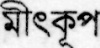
মীৎকূপ
